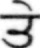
ਤੇ
